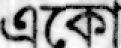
একো
